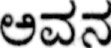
ಅವನ
